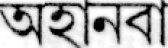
অহানবা
